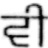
ਵੀ
